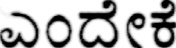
ಎಂದೇಕೆ
